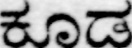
ಕೂಡ
